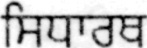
ਸਿਧਾਰਥ
